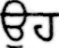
ਉਹ
